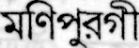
মণিপুরগী
